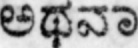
ಅಥವಾ
